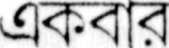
একবার
